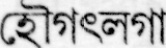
হৌগৎলগা
